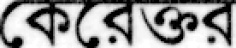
কেরেক্তর
